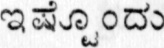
ಇಷ್ಟೊಂದು
